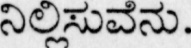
ನಿಲ್ಲಿಸುವೆನು.
